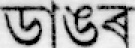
ডাঙৰ
